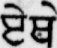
ਏਥੇ
